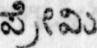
ಪ್ರೇಮಿ
